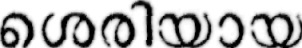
ശെരിയായ
